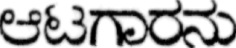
ಆಟಗಾರನು
